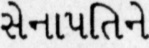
સેનાપતિને
